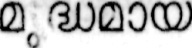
മൃദ്ധമായ
